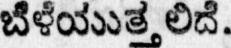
ಬೆಳೆಯುತ್ತಲಿದೆ.
